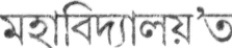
মহাবিদ্যালয়'ত
